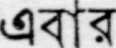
এবার
